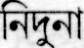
নিদুনা
